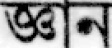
জ্ঞান
